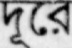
দূরে
